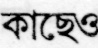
কাছেও
